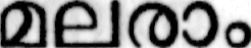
മലരാം
